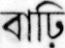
বাঢ়ি
